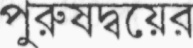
পুরুষদ্বয়ের
